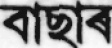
বাছাৰ
